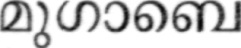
മുഗാബെ
